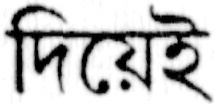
দিরেই
